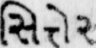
સિત્તેર
